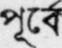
পূর্বে
